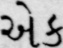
એક
